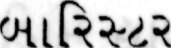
બારિસ્ટર
